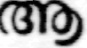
ആ
